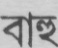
বাহু
